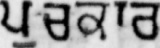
ਪੁਚਕਾਰ
